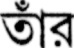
তাঁর
